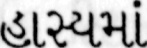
હાસ્યમાં
